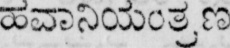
ಹವಾನಿಯಂತ್ರಣ
